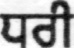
ਧਰੀ
